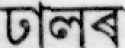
ঢালৰ
